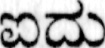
ಐದು
